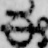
ಈ
